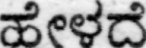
ಹೇಳದೆ
